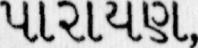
પારાયણ
